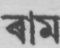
ৰাম
